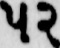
પર
